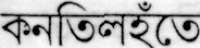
কনতিলহঁতে
